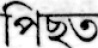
পিছত
